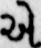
એ
